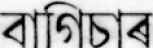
বাগিচাৰ
